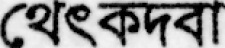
থেৎকদবা
